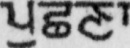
ਪੁਛਣਾ
